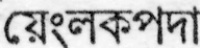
য়েংলকপদা
